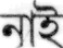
নাই
